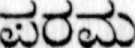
ಪರಮ
